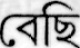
বেছি
